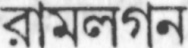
রামলগন
